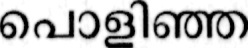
പൊളിഞ്ഞ
